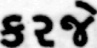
કરજે
